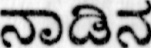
ನಾಡಿನ
